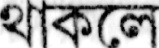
থাকলে
